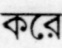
করে
